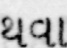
થવા
